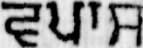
ਵਪਾਸ
